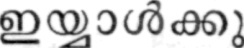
ഇയ്യാള്‍ക്കു
